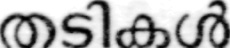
തടികള്‍
